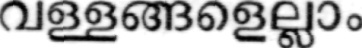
വള്ളങ്ങളെല്ലാം
